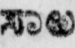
ಸಾಲ
